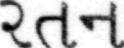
રતન
